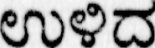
ಉಳಿದ
